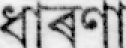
ধাৰণা
